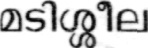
മടിശ്ശീല
